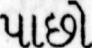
પાછો
